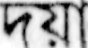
দয়া
